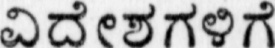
ವಿದೇಶಗಳಿಗೆ
